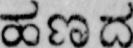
ಹಣದ
